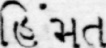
હિંમત
